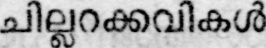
ചില്ലറക്കവികള്‍
